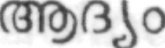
ആദ്യം
